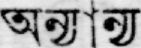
অন্যান্য
